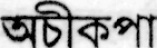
অচীকপা
